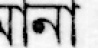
মানা
